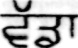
ਵੱਡਾ
